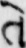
તે
